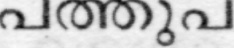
പത്തുപ
